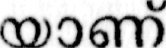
യാണ്
